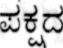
ಪಕ್ಷದ
